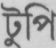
টুপি
